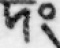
দং
